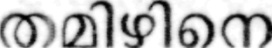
തമിഴിനെ
